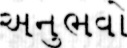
અનુભવો
